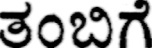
ತಂಬಿಗೆ
